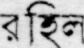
রহিল
